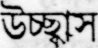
উচ্ছ্বাস
